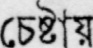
চেষ্টায়
